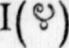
I(೪)
